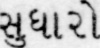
સુધારો
